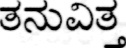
ತನುವಿತ್ತ
